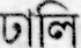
ঢালি
